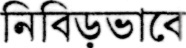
নিবিড়ভাবে
